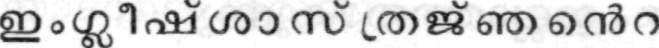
ഇംഗ്ലീഷ്ശാസ്ത്രജ്ഞന്റെ
